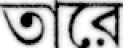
তারে
